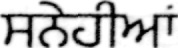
ਸਨੇਹੀਆਂ
